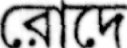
রোদে
